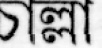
চাল্লা
